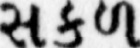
સકળ
